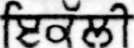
ਇਕੱਲੀ
